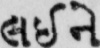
લઈને
